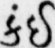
કંઈ
